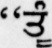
''ਤੂੰ
